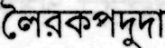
লৈরকপদুদা
